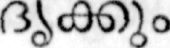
ദൃക്കും
